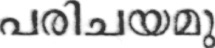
പരിചയമു
